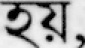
হয়,
